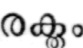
രക്തം
